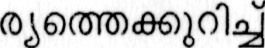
ര്യത്തെക്കുറിച്ച്
